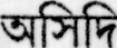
অসিদি
